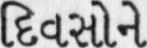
દિવસોને
